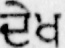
ਦੇਖ
